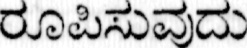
ರೂಪಿಸುವುದು
